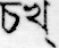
চখ্
